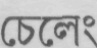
চেলেং
